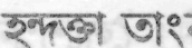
হন্দওা তাং
